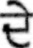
ਦੇ
